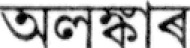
অলঙ্কাৰ
